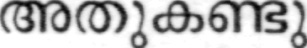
അതുകണ്ടു
